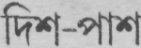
দিশ-পাশ
